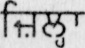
ਜ਼ਿਲ੍ਹਾ
